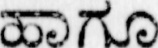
ಹಾಗೂ
